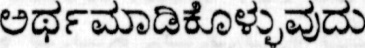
ಅರ್ಥಮಾಡಿಕೊಳ್ಳುವುದು
